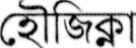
হৌজিক্না
